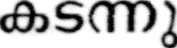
കടന്നു
